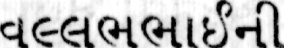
વલ્લભભાઈની
